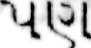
પણ
